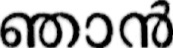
ഞാന്‍
